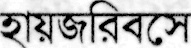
হায়জরিবসে
